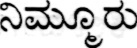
ನಿಮ್ಮೂರು
